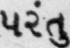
પરંતુ
